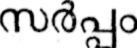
സര്‍പ്പം
